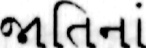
જાતિનાં
